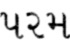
પરમ
